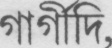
গার্গীদি,
